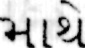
માથે
